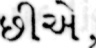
છીએ,
